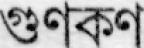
গুণকণ
